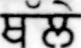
ਥੱਲੇ
